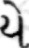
યે
